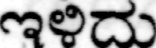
ಇಳಿದು
